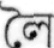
লৈ
